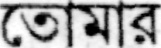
তোমার
